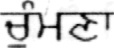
ਚੁੰਮਣਾ
